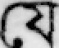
যে
